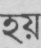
হয়
